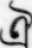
ঐ
